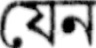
যেন
